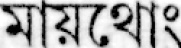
মায়থোং
